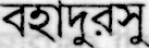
বহাদুরসু
